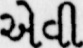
એવી
